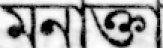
মনাক্তা
